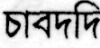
চাবদদি
